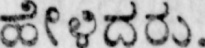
ಹೇಳಿದರು.
